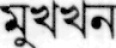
মুখখন
